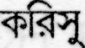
করিসু
